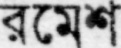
রমেশ
